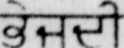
ਭੇਜਦੀ
